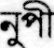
নুপী
